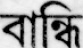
বান্ধি
